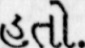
હતો.
